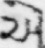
એ
